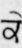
ਕੇ
